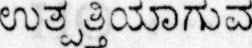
ಉತ್ಪತ್ತಿಯಾಗುವ
